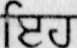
ਇਹ
